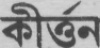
কীৰ্ত্তন
